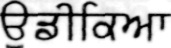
ਉਡੀਕਿਆ
